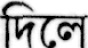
দিলে
